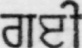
ਗਈ
